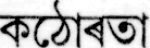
কঠোৰতা
